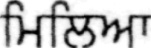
ਮਿਲਿਆ
